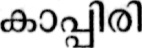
കാപ്പിരി
